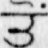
ਤੋਂ
